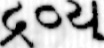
દ્રવ્ય
